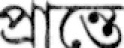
প্রান্তে
